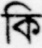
কি
